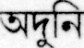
অদুনি
